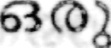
ഒരു
